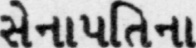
સેનાપતિના
